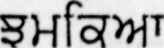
ਝਮਕਿਆ
